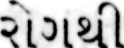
રોગથી
